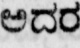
ಅದರ
